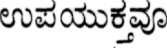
ಉಪಯುಕ್ತವೂ
